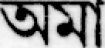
অমা
